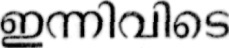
ഇന്നിവിടെ
